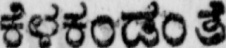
ಕೆಳಕಂಡಂತೆ
